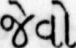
જેવો
